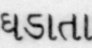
ઘડાતા
